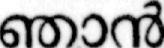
ഞാന്‍
